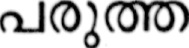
പരുത്ത
